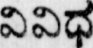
ವಿವಿಧ
